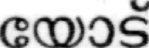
യോട്
